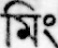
মিং
